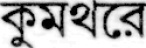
কুমথরে
